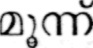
മൂന്ന്
